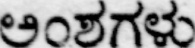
ಅಂಶಗಳು
